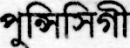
পুন্সিসিগী
